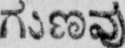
ಗುಣವು
